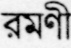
রমণী
